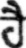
ਹੈ
